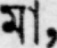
মা,
